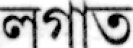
লগাত
